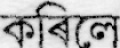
কৰিলে
